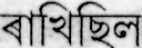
ৰাখিছিল
